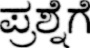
ಪ್ರಶ್ನೆಗೆ
